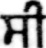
ਸੀ
